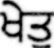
ਖੇਤੁ
